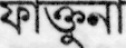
ফাক্তুনা
